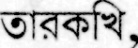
তারকখি,
